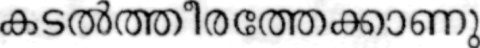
കടല്‍ത്തീരത്തേക്കാണു
